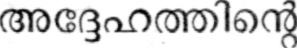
അദ്ദേഹത്തിന്റെ
